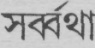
সৰ্ব্বথা
